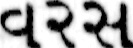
વરસ
